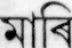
মাৰি
